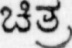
ಚಿತ್ರ
